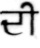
ਦੀ
